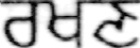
ਰਖਣ
